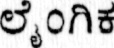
ಲೈಂಗಿಕ
